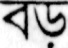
বড়
